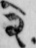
રે.
